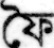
ফৈ
